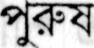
পুরুষ
